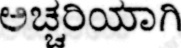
ಅಚ್ಚರಿಯಾಗಿ
